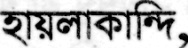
হায়লাকান্দি,
